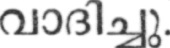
വാദിച്ചു.
